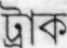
ট্রাক
